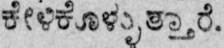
ಕೇಳಿಕೊಳ್ಳುತ್ತಾರೆ.
